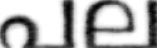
പല
